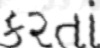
કરતાં
